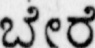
ಬೇರೆ
